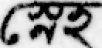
স্নেহ
